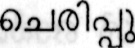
ചെരിപ്പു
